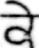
ਕੇ
